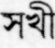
সখী
